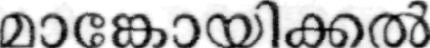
മാങ്കോയിക്കല്‍
